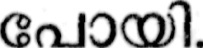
പോയി.
